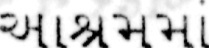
આશ્રમમાં
